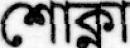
শোক্না
